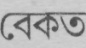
বেকত
